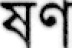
ষণ
